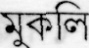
মুকলি
